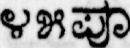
೪೫ಪೂ
